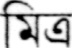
মিত্র
